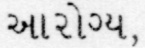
આરોગ્ય,
